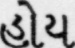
હોય
